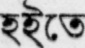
হইতে
